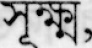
সূক্ষ্ম,
